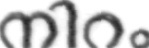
നിറം
